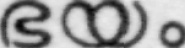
ഭയം
